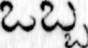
ಒಬ್ಬ
